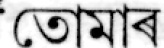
'তোমাৰ
